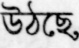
উঠছে,
